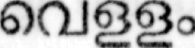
വെള്ളം
